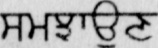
ਸਮਝਾਉਣ
